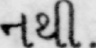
નથી.
